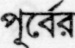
পূর্বের
